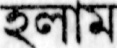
হলাম
